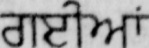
ਗਈਆਂ
